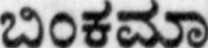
ಬಿಂಕಮಾ
